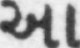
આ
